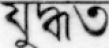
যুদ্ধত
